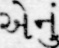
એનું
